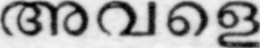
അവളെ
